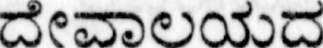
ದೇವಾಲಯದ
